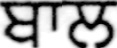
ਬਾਲ
